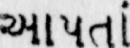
આપતાં
